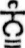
ਨੂੰ
